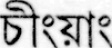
চীংয়াং
